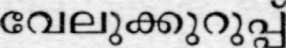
വേലുക്കുറുപ്പ്
